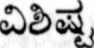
ವಿಶಿಷ್ಟ
